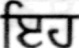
ਇਹ
